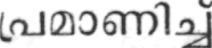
പ്രമാണിച്ച്
